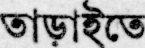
তাড়াইতে
